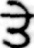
ਤੇ
